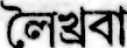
লৈখ্রবা
